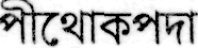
পীথোকপদা
